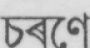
চৰণে
